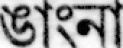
ঙাংনা
